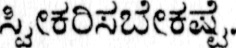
ಸ್ವೀಕರಿಸಬೇಕಷ್ಟೆ.
